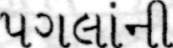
પગલાંની
